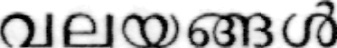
വലയങ്ങള്‍
